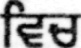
ਵਿਚ
